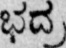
ಭದ್ರ
